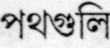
পথগুলি
